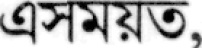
এসময়ত,
